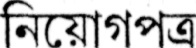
নিয়োগপত্র
